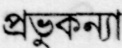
প্রভুকন্যা
